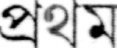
প্রথম
